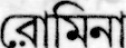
রোমিনা
